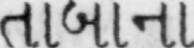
તાબાના
